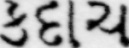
કદાચ
